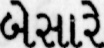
બેસારે
